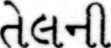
તેલની
